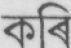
কৰি
